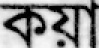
কয়া
